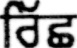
ਰਿੱਛ
